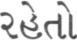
રહેતો
